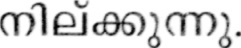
നില്ക്കുന്നു.
